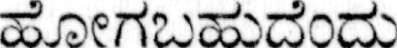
ಹೋಗಬಹುದೆಂದು
